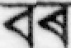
বৰ
